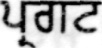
ਪ੍ਰਗਟ
